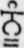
ਨੂੰ
